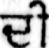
ਦੀ
